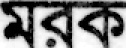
মরক
